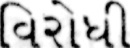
વિરોધી
